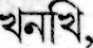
খনখি,
